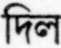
দিল
